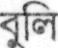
বুলি
